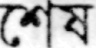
শেষ
